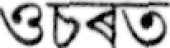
ওচৰত
